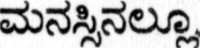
ಮನಸ್ಸಿನಲ್ಲೂ
